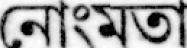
নোংমতা
